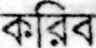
করিব
